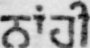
ਨਾਂਹੀ
